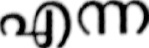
എന്ന
